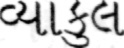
વ્યાકુળ
